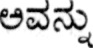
ಅವನ್ನು
